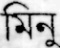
মিনু
